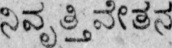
ನಿವೃತ್ತಿವೇತನ
